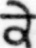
ਕੇ
